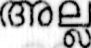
അല്ല
